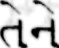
તેને
